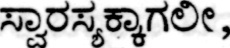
ಸ್ವಾರಸ್ಯಕ್ಕಾಗಲೀ,
